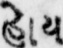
હોય
